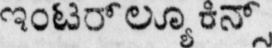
ಇಂಟರ್‌ಲ್ಯೂಕಿನ್ಸ್
